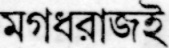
মগধরাজই
